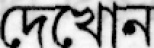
দেখোন
